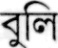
বুলি
